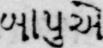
બાપુએ
